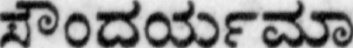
ಸೌಂದರ್ಯಮಾ
